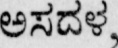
ಅಸದಳ,
